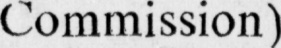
Commission)
